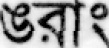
ঙরাং
